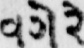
વગેરે
